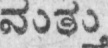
ಮತ್ತು
